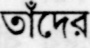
তাঁদের
